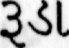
રૂડા
